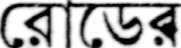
রোডের
